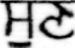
ਸੁਣ
